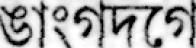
ঙাংগদগে
